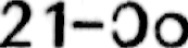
21-ാം
